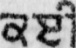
ਕਈ
